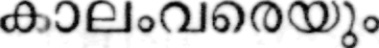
കാലംവരെയും
